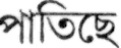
পাতিছে
